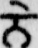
ਨੇ
